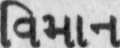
વિમાન
